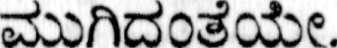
ಮುಗಿದಂತೆಯೇ.
